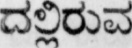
ದಲ್ಲಿರುವ
